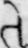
તે
